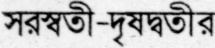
সরস্বতী-দৃষদ্বতীর
